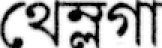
থেম্লগা
